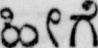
ಹೀಗೆ
